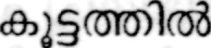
കൂട്ടത്തില്‍
